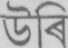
উৰি
